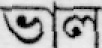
ভাল
